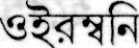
ওইরম্বনি
